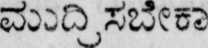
ಮುದ್ರಿಸಬೇಕಾ
